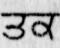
ਤਕ
